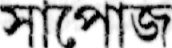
সাপোজ
